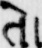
તો
